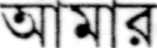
আমার
